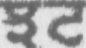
ਝਟ
